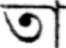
তা
